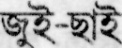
জুই-ছাই
